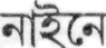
নাইনে
